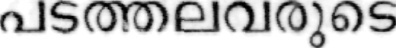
പടത്തലവരുടെ
